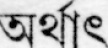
অর্থাৎ
